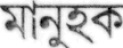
মানুহক
